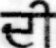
ਦੀ
